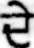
ਦੇ
